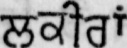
ਲਕੀਰਾਂ
